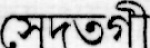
সেদতগী
